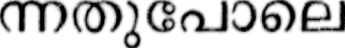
ന്നതുപോലെ
